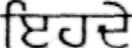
ਇਹਦੇ
